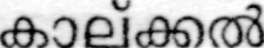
കാല്ക്കല്‍
